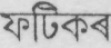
ফটিকৰ
